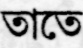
তাতে
